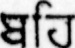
ਬਹਿ
